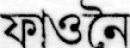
ফাওনৈ
